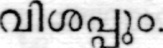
വിശപ്പും.
